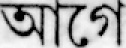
আগে
